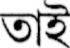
তাই
